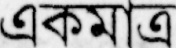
একমাত্র
